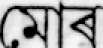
মোৰ
